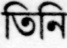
তিনি
